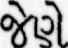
જેણે
